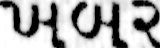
ખબર
